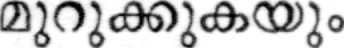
മുറുക്കുകയും
